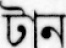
টান
